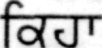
ਕਿਹਾ
